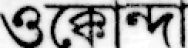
ওক্কোন্দা
